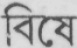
বিষে
